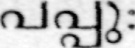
പപ്പു:
